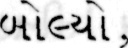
બોલ્યો,
